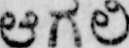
ಆಗಲಿ
